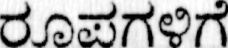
ರೂಪಗಳಿಗೆ
